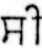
ਸੀ
